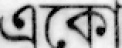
একো
